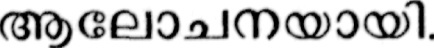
ആലോചനയായി.
